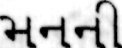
મનની
